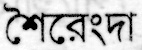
শৈরেংদা
